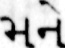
મને
